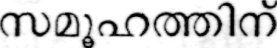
സമൂഹത്തിന്
